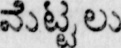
ಮೆಟ್ಟಲು
